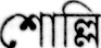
শোল্লি
